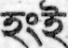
হংই
